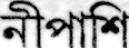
নীপাশি
